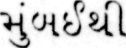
મુંબઈથી
